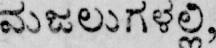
ಮಜಲುಗಳಲ್ಲಿ,
